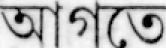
আগতে
